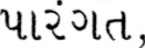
પારંગત,
